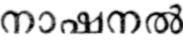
നാഷനല്‍
